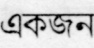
একজন
